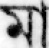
মা
